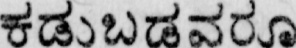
ಕಡುಬಡವರೂ
